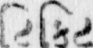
ટિકિટ
